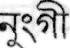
নুংগী
